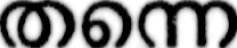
തന്നെ
